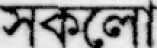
সকলো
